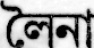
লৈনা
